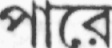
পারে
